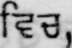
ਵਿਚ,
